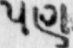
પણ
